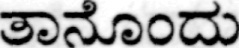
ತಾನೊಂದು
